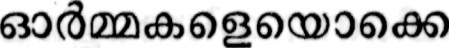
ഓര്‍മ്മകളെയൊക്കെ
